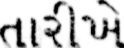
તારીખે
